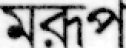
মরূপ
